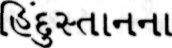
હિંદુસ્તાનના
